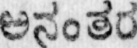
ಅನಂತರ
